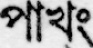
পাখং
